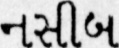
નસીબ
